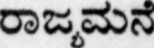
ರಾಜ್ಯಮನೆ
